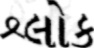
શ્લોક
